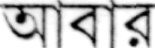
আবার
